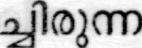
ച്ചിരുന്ന
